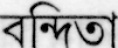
বন্দিতা
